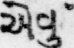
એવું
